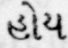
હોય
